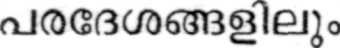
പരദേശങ്ങളിലും
